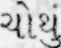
ચોથું
